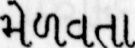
મેળવતા
